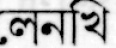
লেনখি
